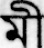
মী
